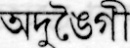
অদুঙৈগী
